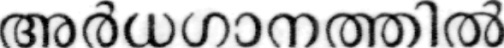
അര്‍ധഗാനത്തില്‍
